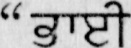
''ਭਾਈ
